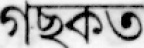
গছকত
